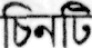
চিনটি
